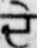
ਦੇ
